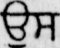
ਉਸ
